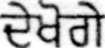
ਦੇਖੋਗੇ
